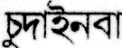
চুদাইনবা
